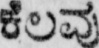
ಕೆಲವು
